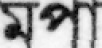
মপা
